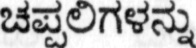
ಚಪ್ಪಲಿಗಳನ್ನು
